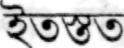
ইতস্তত
